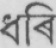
ধৰি
